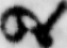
જ
